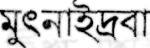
মুৎনাইদ্রবা
